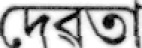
দেৱতা
